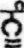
ਨੂੰ
